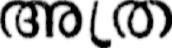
അത്ര
